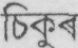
চিকুৰ
